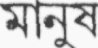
মানুষ
